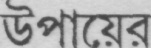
উপায়ের
